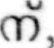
ന്,
